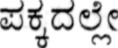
ಪಕ್ಕದಲ್ಲೇ
